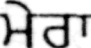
ਮੇਰਾ
